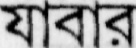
যাবার
